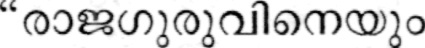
"രാജഗുരുവിനെയും
